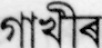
গাখীৰ
